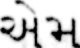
એમ
